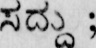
ಸದ್ದು;
